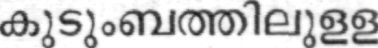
കുടുംബത്തിലുളള
